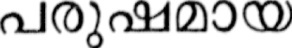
പരുഷമായ
